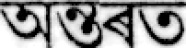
অন্তৰত
